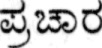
ಪ್ರಚಾರ
